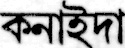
কনাইদা
